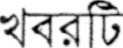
খবরটি
